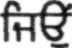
ਜਿਉਂ
